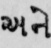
અને
